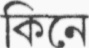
কিনে
